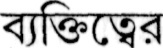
ব্যক্তিত্বের
